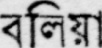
বলিয়া
